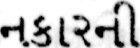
નકારની
